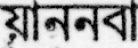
য়াননবা
